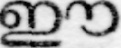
ഈ
